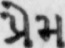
પ્રેમ
